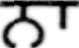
ਨਾ
